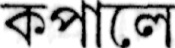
কপালে
